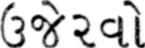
ઉજેરવો
